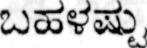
ಬಹಳಷ್ಟು
